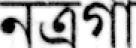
নত্রগা
